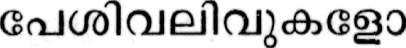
പേശിവലിവുകളോ
